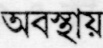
অবস্থায়
